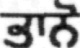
ਭਾਨੋ
